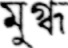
মুগ্ধ
